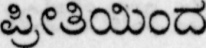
ಪ್ರೀತಿಯಿಂದ
